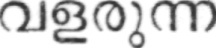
വളരുന്ന
